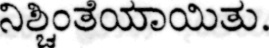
ನಿಶ್ಚಿಂತೆಯಾಯಿತು.
